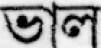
ভাল
